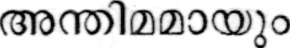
അന്തിമമായും
